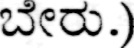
ಬೇರು.)
